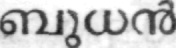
ബുധന്‍
